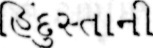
હિંદુસ્તાની
